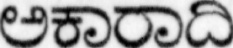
ಅಕಾರಾದಿ
